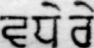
ਵਧੇਰੇ
